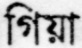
গিয়া
